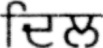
ਦਿਲ
